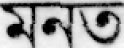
মনত
